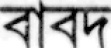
বাবদ
